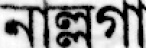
নাল্লগা
